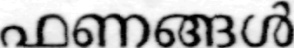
ഫണങ്ങള്‍
